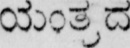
ಯಂತ್ರದ
